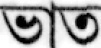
ভাত
